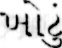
ખોટું
